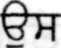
ਉਸ
